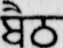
ਬੈਠ
